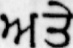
ਅਤੇ
